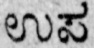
ಉಪ
